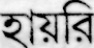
হায়রি
